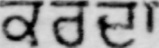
ਕਰਦਾ
